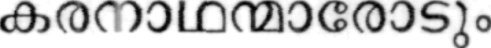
കരനാഥന്മാരോടും
